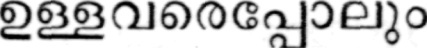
ഉള്ളവരെപ്പോലും
